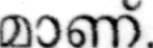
മാണ്.
